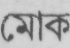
মোক
